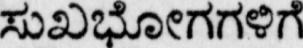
ಸುಖಭೋಗಗಳಿಗೆ
